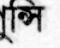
পুন্সি
